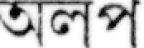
অলপ
